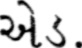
એડ.
